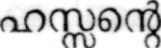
ഹസ്സന്റെ
